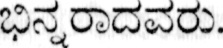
ಭಿನ್ನರಾದವರು.
